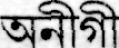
অনীগী
